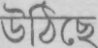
উঠিছে
